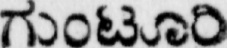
ಗುಂಟೂರಿ
